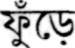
ফুঁড়ে
